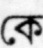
কে
